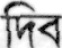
দিব
